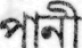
পানী
